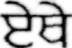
ਏਥੇ
